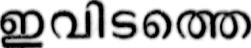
ഇവിടത്തെ
